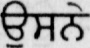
ਉਸਨੇ
